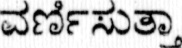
ವರ್ಣಿಸುತ್ತಾ
